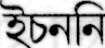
ইচননি
